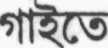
গাইতে
